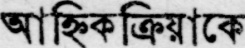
আহ্নিকক্রিয়াকে
